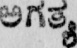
ಅಗತ್ಯ
